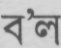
ব'ল
